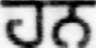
ਹਨ
